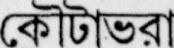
কৌটাভরা
